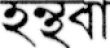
হন্থবা
